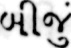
બીજું
